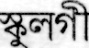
স্কুলগী
